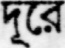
দূরে
